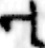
ન
